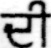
ਦੀ
